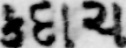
કદાચ
